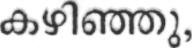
കഴിഞ്ഞു,
